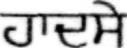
ਹਾਦਸੇ
